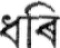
ধৰি
